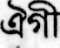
ঐগী
